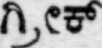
ಗ್ರೀಕ್
